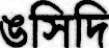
ঙসিদি
